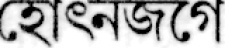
হোৎনজগে
